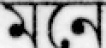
মনে
